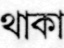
থাকা
